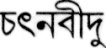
চৎনবীদু
